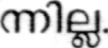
ന്നില്ല.
